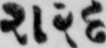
શરદ
